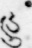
હું
